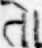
તો
